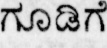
ಗೂಡಿಗೆ
